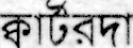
ক্বর্টরদা
